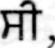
ਸੀ,
